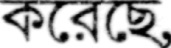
করেছে,
